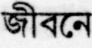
জীবনে
